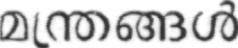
മന്ത്രങ്ങള്‍
